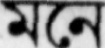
মনে
